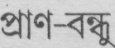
প্ৰাণ-বন্ধু
